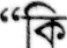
"কি
